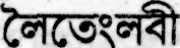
লৈতেংলবী
